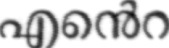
എന്റെ
